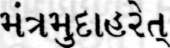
મંત્રમુદાહરેત્
